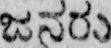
ಜನರು
